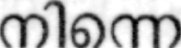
നിന്നെ
